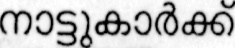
നാട്ടുകാര്‍ക്ക്
